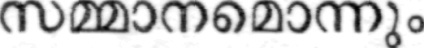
സമ്മാനമൊന്നും
